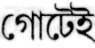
গোটেই
